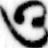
ও
